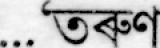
..."তৰুণ
